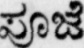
ಪೂಜೆ
